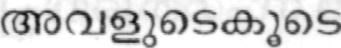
അവളുടെകൂടെ
